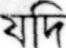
যদি
